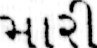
મારી
